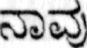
ನಾವು
